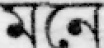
মনে
